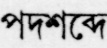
পদশব্দে
